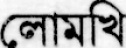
লোমখি
